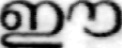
ഈ
